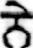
ਨੇ
